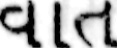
વાત
